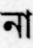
না
